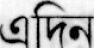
এদিন
